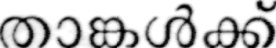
താങ്കള്‍ക്ക്
